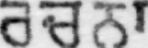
ਰਚਨਾ
